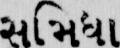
સમિધા
